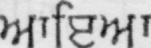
ਆਇਆ
